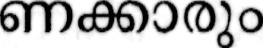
ണക്കാരും
